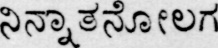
ನಿನ್ನಾತನೋಲಗ
